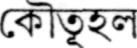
কৌতূহল
